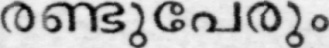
രണ്ടുപേരും
